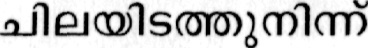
ചിലയിടത്തുനിന്ന്
